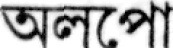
অলপো
